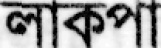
লাকপা
